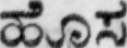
ಹೊಸ
